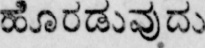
ಹೊರಡುವುದು
